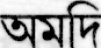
অমদি
